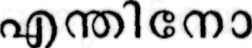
എന്തിനോ
